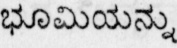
ಭೂಮಿಯನ್ನು
